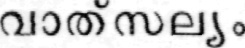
വാത്സല്യം
